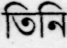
তিনি
